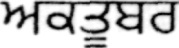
ਅਕਤੂਬਰ
